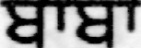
ਬਾਬਾ
